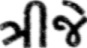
ત્રીજે
